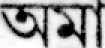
অমা
